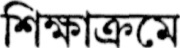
শিক্ষাক্রমে
